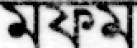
মফম
